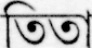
তিতা
